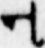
ન
